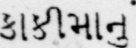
કાકીમાનું
